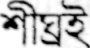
শীঘ্রই
